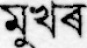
মুখৰ
